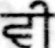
ਵੀ
